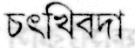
চৎখিবা
